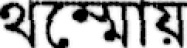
থম্মোয়
